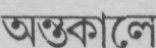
অন্তকালে
